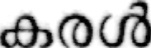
കരള്‍
